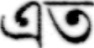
এত
